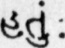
હતું:
